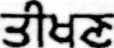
ਤੀਖਣ
